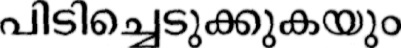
പിടിച്ചെടുക്കുകയും
